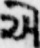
એ
